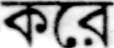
করে
